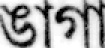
ঙাগা
